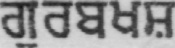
ਗੁਰਬਖਸ਼
